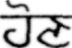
ਹੋਣ
